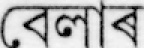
বেলাৰ
